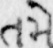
તમે
